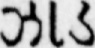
ઝાડ
